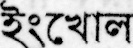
ইংখোল
